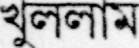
খুললাম
